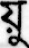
য়ু
